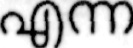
എന്ന
